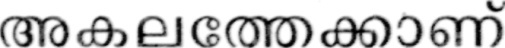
അകലത്തേക്കാണ്
